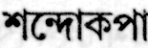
শন্দোকপা
